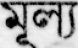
মূল্য
